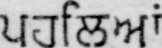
ਪਹਲਿਆਂ
